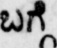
ಬಗ್ಗೆ
